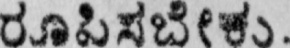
ರೂಪಿಸಬೇಕು.
